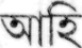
আহি
